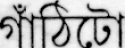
গাঁঠিটো
